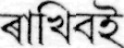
ৰাখিবই
